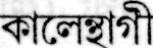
কালেন্থাগী
